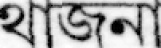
থাজনা
